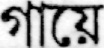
গায়ে
